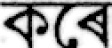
কৰে
